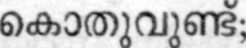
കൊതുവുണ്ട്;
